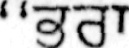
''ਭਰਾ
